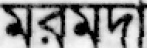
মরমদা
